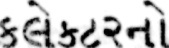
કલેક્ટરનો
